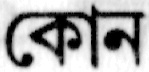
কোন
